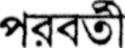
পরবর্তী
